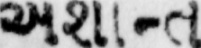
અશાન્ત
